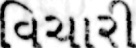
વિચારી
